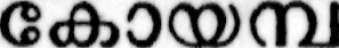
കോയമ്പ
